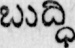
ಬುದ್ಧಿ
